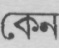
কেন
